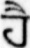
ਹੈ
